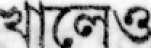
খালেও
